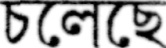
চলেছে
